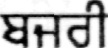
ਬਜਰੀ
